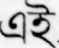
এই
